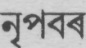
নৃপবৰ
